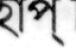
হাপ্
